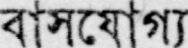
বাসযোগ্য
